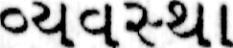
વ્યવસ્થા
